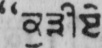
''ਕੁੜੀਏ
